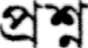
প্রশ্ন
